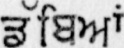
ਡੱਬਿਆਂ
